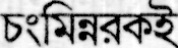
চংমিন্নরকই
